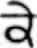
ਕੇ
